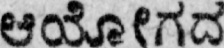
ಆಯೋಗದ
